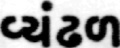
વ્યંઢળ
